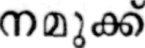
നമുക്ക്
